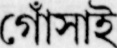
গোঁসাই
